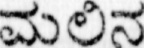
ಮಲಿನ
